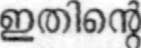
ഇതിന്റെ
